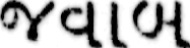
જવાબ
